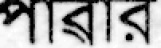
পাৱার
